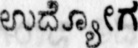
ಉದ್ಯೋಗ
